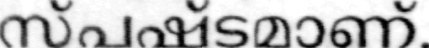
സ്പഷ്ടമാണ്.
